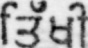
ਤਿੱਖੀ
